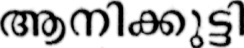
ആനിക്കുട്ടി
